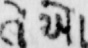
તેઓ
